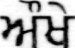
ਔਖੇ
